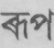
ৰূপ
